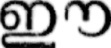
ഈ
